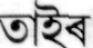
তাইৰ
